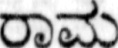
ರಾಮ
